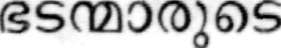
ഭടന്മാരുടെ
